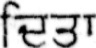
ਦਿਤਾ
